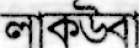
লাকউবা
